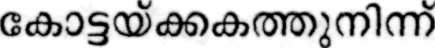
കോട്ടയ്ക്കകത്തുനിന്ന്
